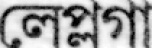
লেপ্লগা
